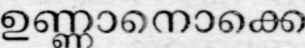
ഉണ്ണാനൊക്കെ
